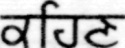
ਕਹਿਣ
